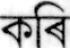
কৰি
